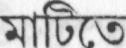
মাটিতে
